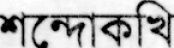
শন্দোকখি
